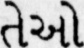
તેઓ
